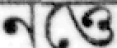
নত্তে
